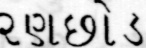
રણછોડ
